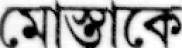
মোস্তাকে
